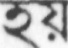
হয়
